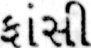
ફાંસી
